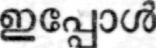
ഇപ്പോള്‍
